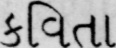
કવિતા
